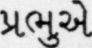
પ્રભુએ
